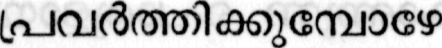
പ്രവര്‍ത്തിക്കുമ്പോഴേ
